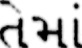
તેમાં
